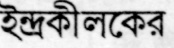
ইন্দ্রকীলকের
